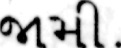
જામી.
